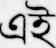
এই
